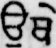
ਉਥੇ
